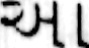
આ
